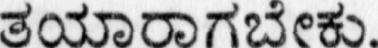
ತಯಾರಾಗಬೇಕು.
